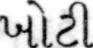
ખોટી
